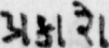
પ્રકારો
